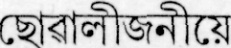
ছোৱালীজনীয়ে
